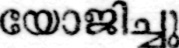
യോജിച്ചു
